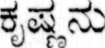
ಕೃಷ್ಣನು
